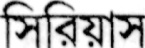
সিরিয়াস
